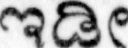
ಇಡೀ
